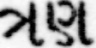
ત્રણ
